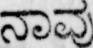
ನಾವು
